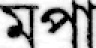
মপা
